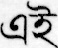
এই
